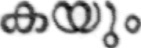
കയും
